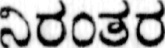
ನಿರಂತರ
